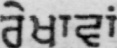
ਰੇਖਾਵਾਂ
